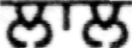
ਲਾਲ
